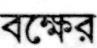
বক্ষের
